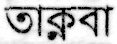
তাক্নবা
